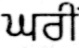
ਘਰੀਂ
